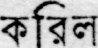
করিল
